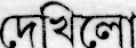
দেখিলো
